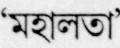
‘মহালতা’
